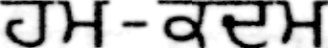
ਹਮ-ਕਦਮ
